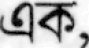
এক,
